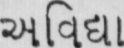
અવિધા
